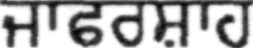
ਜਾਫਰਸ਼ਾਹ
